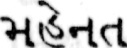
મહેનત
